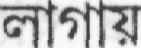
লাগায়
